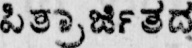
ಪಿತ್ರಾರ್ಜಿತದ
